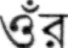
ওঁর
